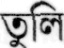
তুলি
